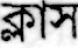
ক্লাস
